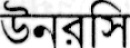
উনরসি
